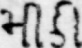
મીઠી
